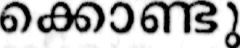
ക്കൊണ്ടു
